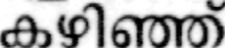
കഴിഞ്ഞ്
